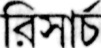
রিসার্চ
